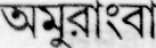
অমুরাংবা
